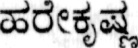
ಹರೇಕೃಷ್ಣ
